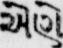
એણે
